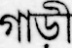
গাড়ী
